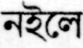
নইলে
